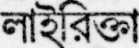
লাইরিক্তা
